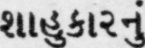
શાહુકારનું
